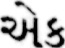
એક
